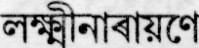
লক্ষ্মীনাৰায়ণে
